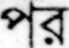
পর
